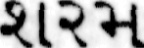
શરમ
